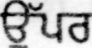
ਉੱਪਰ
